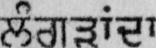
ਲੰਗੜਾਂਦਾ
